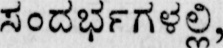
ಸಂದರ್ಭಗಳಲ್ಲಿ,
